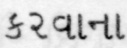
કરવાના
